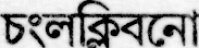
চংলক্লিবনো
